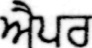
ਐਪਰ
